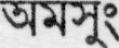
অমসুং
